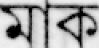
মাক
